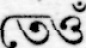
তেওঁ
